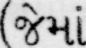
(જેમાં
